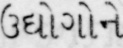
ઉધોગોને
